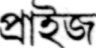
প্রাইজ
